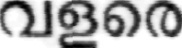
വളരെ
